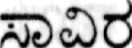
ಸಾವಿರ
